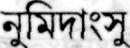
নুমিদাংসু
